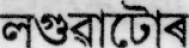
লগুৱাটোৰ
